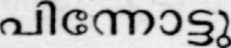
പിന്നോട്ടു
